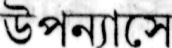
উপন্যাসে
